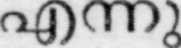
എന്നു
